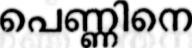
പെണ്ണിനെ
